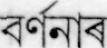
বর্ণনাৰ
